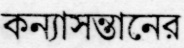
কন্যাসন্তানের
